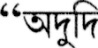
“অদুদি
